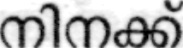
നിനക്ക്
